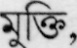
মুক্তি,
